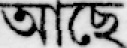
আছে
